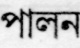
পালন
